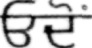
ਓਦੋਂ
